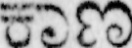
ಕಾಣ
